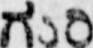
ಗುರಿ
